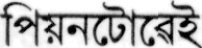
পিয়নটোৱেই
